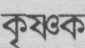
কৃষ্ণক
